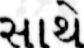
સાથે
